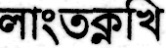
লাংতক্নখি
